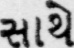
સાથે
